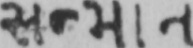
સન્માન
